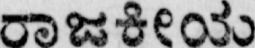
ರಾಜಕೀಯ
